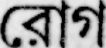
রোগ
